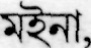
মইনা,
